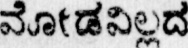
ಮೋಡವಿಲ್ಲದ
